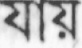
যায়
